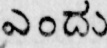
ಎಂದು
